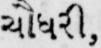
ચૌધરી,
